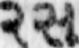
રસ
